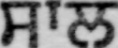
ਸਾਲ
